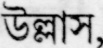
উল্লাস,
